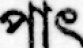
পাৎ
